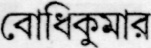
বোধিকুমার
